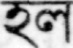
হল
